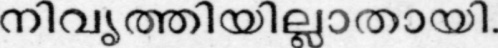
നിവൃത്തിയില്ലാതായി.
